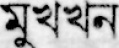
মুখখন
